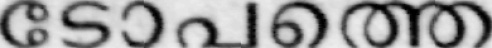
ടോപത്തെ
